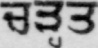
ਚੜ੍ਹਤ
